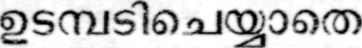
ഉടമ്പടിചെയ്യാതെ
